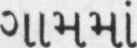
ગામમાં
